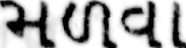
મળવા
